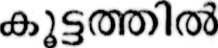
കൂട്ടത്തില്‍
